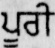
ਪੂਰੀ
